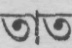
তাত
